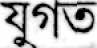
যুগত
